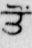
ਤੋਂ
